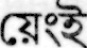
য়েংই
